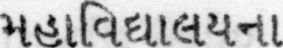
મહાવિધાલયના
